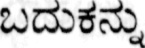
ಬದುಕನ್ನು
